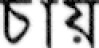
চায়
